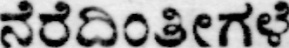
ನೆರೆದಿಂತೀಗಳೆ
